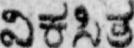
ವಿಕಸಿತ
